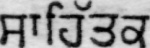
ਸਾਹਿੱਤਕ
